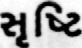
સૃષ્ટિ
